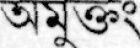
অমুক্তং
